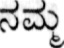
ನಮ್ಮ
